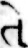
તે
